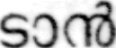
ടാന്‍
